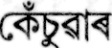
কেঁচুৱাৰ
